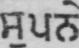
ਸੁਪਨੇ
